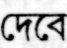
দেবে
